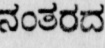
ನಂತರದ
